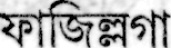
ফাজিল্লগা
